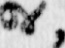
જ,
